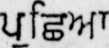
ਪੁਛਿਆ
